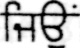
ਜਿਉਂ
